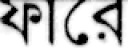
ফারে
